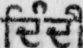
ਦਿੰਦੀ
